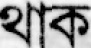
থাক
